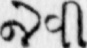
જેવી
